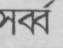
সৰ্ব্ব
